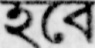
হবে
